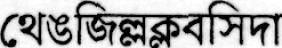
থেঙজিল্লক্লবসিদা
